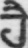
ਹੈ
